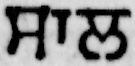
ਸਾਲ
